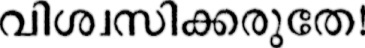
വിശ്വസിക്കരുതേ!
